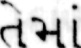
તેમાં
